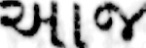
આજ
